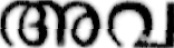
അവ
